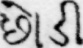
છોડી
